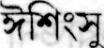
ঈশিংসু
